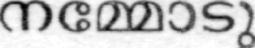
നമ്മോടു
